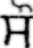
ਸੌ
